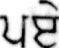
ਪਏ
